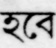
হবে
